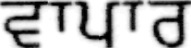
ਵਾਪਾਰ
